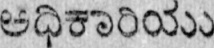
ಅಧಿಕಾರಿಯು
